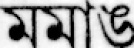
মমাঙ
